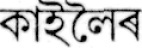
কাইলৈৰ
